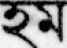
হম
